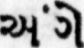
અંગે
